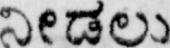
ನೀಡಲು
